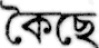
কৈছে
